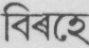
বিৰহে
